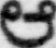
ಆ
